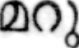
മറു
